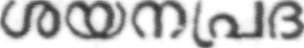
ശയനപ്രദ
